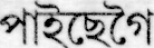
পাইছেগৈ
